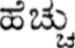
ಹೆಚ್ಚು
